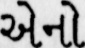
એનો
